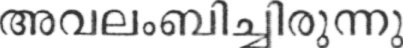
അവലംബിച്ചിരുന്നു
